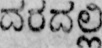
ದರದಲ್ಲಿ
